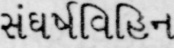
સંઘર્ષવિહિન
